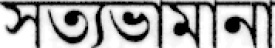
সত্যভামানা
